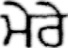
ਮੇਰੇ
